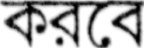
করবে
